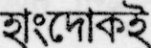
হাংদোকই
